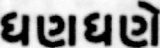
ધણધણે
